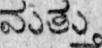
ಮತ್ತು
